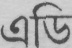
এড়ি
